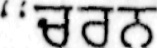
''ਚਰਨ
